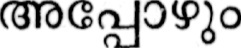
അപ്പോഴും
